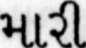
મારી
